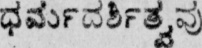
ಧರ್ಮದರ್ಶಿತ್ವವು
